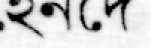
হেনদে
